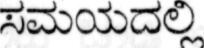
ಸಮಯದಲ್ಲಿ
